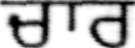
ਚਾਰ
